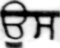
ਉਸ
